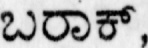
ಬರಾಕ್,
